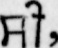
ਸੀ,
